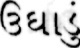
ઉઘાડું
